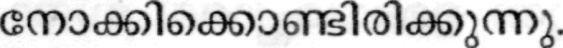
നോക്കിക്കൊണ്ടിരിക്കുന്നു.
